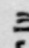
ਹੈ
